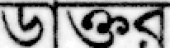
ডাক্তর
